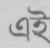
এই
